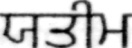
ਯਤੀਮ
